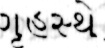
ગૃહસ્થે
